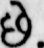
છે.
